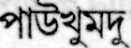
পাউখুমদু
